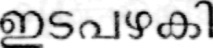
ഇടപഴകി
